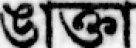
ঙাক্তা
